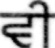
ਵੀ
